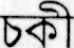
চকী
